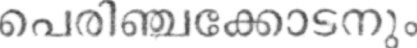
പെരിഞ്ചക്കോടനും
